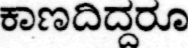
ಕಾಣದಿದ್ದರೂ
